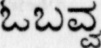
ಓಬವ್ವ
